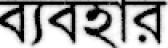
ব্যবহার
